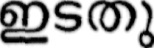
ഇടതു
